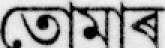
তোমাৰ
